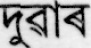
দুৱাৰ
